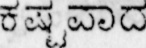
ಕಷ್ಟವಾದ
